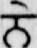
ਨੇ
